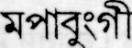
মপাবুংগী
